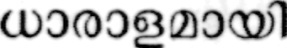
ധാരാളമായി
